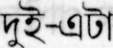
দুই-এটা
